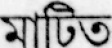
মাটিত
